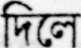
দিলে
